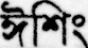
ঈশিং
